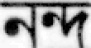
নন্দ
